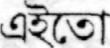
এইতো
